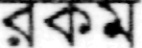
রকম
